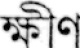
ক্ষীণ
